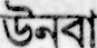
উনবা
